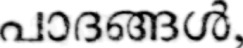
പാദങ്ങള്‍,
